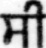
ਸੀ
